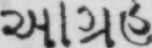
આગ્રહ
